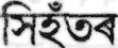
সিহঁতৰ
